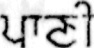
ਪਾਣੀ
